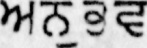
ਅਨੁਭਵ
